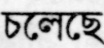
চলেছে
